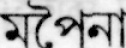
মপৈনা
